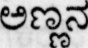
ಅಣ್ಣನ
